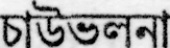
চাউভলনা
